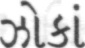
ઝોકાં
